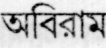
অবিরাম
